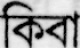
কিবা
